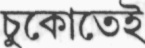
চুকোতেই
